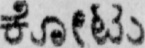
ಕೋಟು
